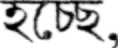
হচ্ছে,
